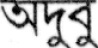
অদুবু
